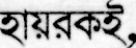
হায়রকই,
